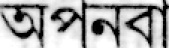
অপনবা
